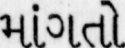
માંગતો
